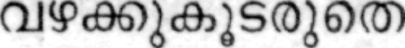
വഴക്കുകൂടരുതെ
